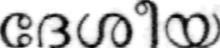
ദേശീയ
